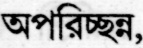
অপরিচ্ছন্ন,
